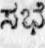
ಸಭೆ
